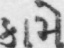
કામે
